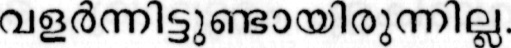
വളര്‍ന്നിട്ടുണ്ടായിരുന്നില്ല.
